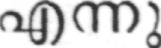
എന്നു
